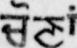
ਚੋਣਾਂ
